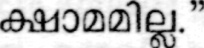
ക്ഷാമമില്ല.”
